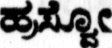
ಹ್ರಸ್ವೋ
